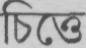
চিত্তে
